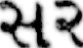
સર
